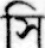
সি
